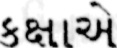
કક્ષાએ
